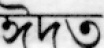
ঈদত
